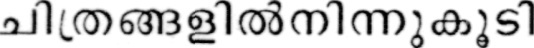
ചിത്രങ്ങളില്‍നിന്നുകൂടി
